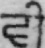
ਵੀ
